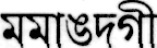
মমাঙদগী
